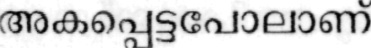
അകപ്പെട്ടപോലാണ്
